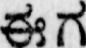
ಈಗ
